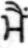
ਮੈਂ
